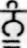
ਨੂੰ
